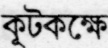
কূটকক্ষে
